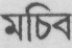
মচিব
